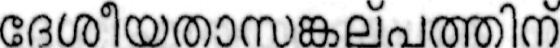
ദേശീയതാസങ്കല്പത്തിന്
